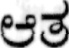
ಆತ
